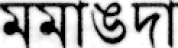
মমাঙদা
